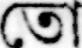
তো
